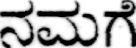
ನಮಗೆ
